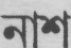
নাশ
